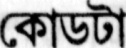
কোডটা
